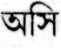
অসি
